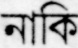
নাকি
